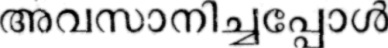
അവസാനിച്ചപ്പോള്‍
